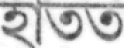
হাতত
